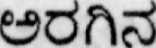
ಅರಗಿನ
